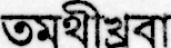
তমথীখ্রবা
